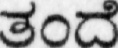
ತಂದೆ
